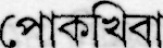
পোকখিবা
